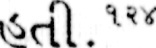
હતી.૧૨૪
